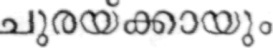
ചുരയ്ക്കായും
